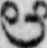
ಆ
